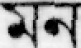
মন
